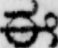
ಈ
